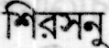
শিরসনু
